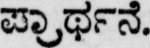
ಪ್ರಾರ್ಥನೆ,
